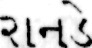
રાનડે
